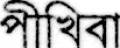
পীখিবা
